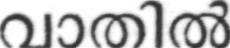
വാതില്‍
